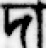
দা
